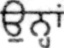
ਉਨ੍ਹਾਂ
